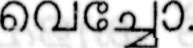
വെച്ചോ.
